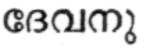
ദേവനു
